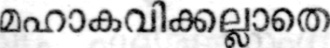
മഹാകവിക്കല്ലാതെ
